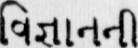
વિજ્ઞાનની
